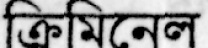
ক্রিমিনেল
